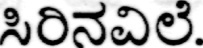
ಸಿರಿನವಿಲೆ.
